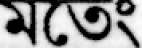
মতেং
